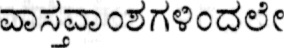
ವಾಸ್ತವಾಂಶಗಳಿಂದಲೇ
